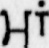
ਮਾਂ
